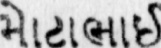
મોટાભાઈ
